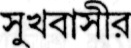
সুখবাসীর
